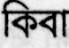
কিবা
